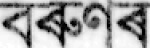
বৰুণৰ
